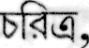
চরিত্র,
